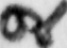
જ
